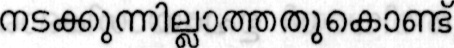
നടക്കുന്നില്ലാത്തതുകൊണ്ട്
